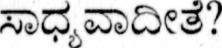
ಸಾಧ್ಯವಾದೀತೆ?
